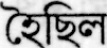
হৈছিল
